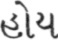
હોય
